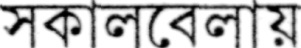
সকালবেলায়
